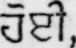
ਹੋਈ,
